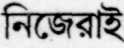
নিজেরাই
